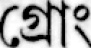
গ্রোং
